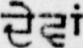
ਦੇਵਾਂ
